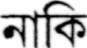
নাকি
